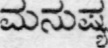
ಮನುಷ್ಯ
